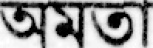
অমতা
